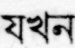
যখন
